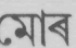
মোৰ
